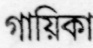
গায়িকা
